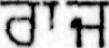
ਰਾਜ
